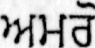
ਅਮਰੋ
